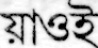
য়াওই
